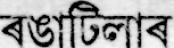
ৰঙাটিলাৰ
